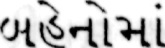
બહેનોમાં
